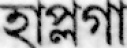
হাপ্লগা
